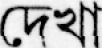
দেখা
